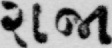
રાજા
